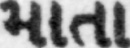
માતા
